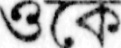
ওকে
